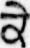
ਕੇ
